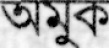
অমুক
